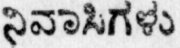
ನಿವಾಸಿಗಳು
